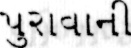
પુરાવાની
